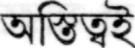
অস্তিত্বই
